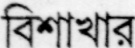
বিশাখার
